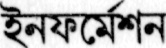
ইনফর্মেশন
